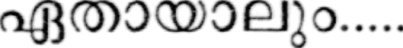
ഏതായാലും....
